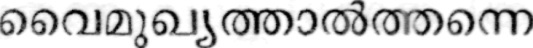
വൈമുഖ്യത്താല്‍ത്തന്നെ
